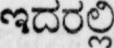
ಇದರಲ್ಲಿ
